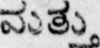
ಮತ್ತು
